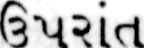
ઉપરાંત
